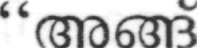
"അങ്ങ്
